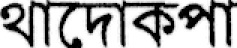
থাদোকপা
